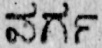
ವರ್ಗ
